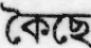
কৈছে
